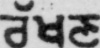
ਰੱਖਣ
